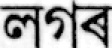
লগৰ
